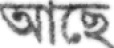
আছে
